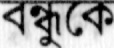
বন্ধুকে
